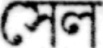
সেল
